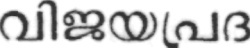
വിജയപ്രദ
